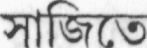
সাজিতে
